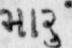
મારું
